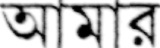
আমার
